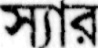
স্যার
